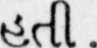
હતી.
